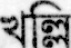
খল্লি
